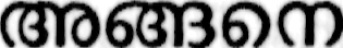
അങ്ങനെ
